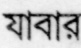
যাবার
